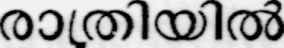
രാത്രിയില്‍
